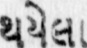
થયેલા
